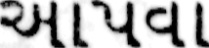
આપવા
